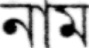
নাম
